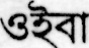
ওইবা
